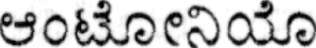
ಆಂದೋನಿಯೊ
